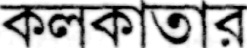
কলকাতার
